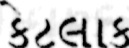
કેટલાક
